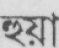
হুয়া
